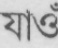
যাওঁ
